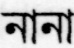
নানা
